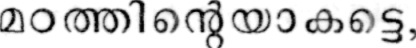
മഠത്തിന്റെയാകട്ടെ,
